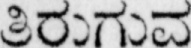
ತಿರುಗುವ
